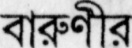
বারুণীর
